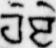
ਹੋਏ
